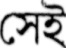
সেই
